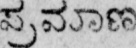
ಪ್ರಮಾಣ
